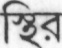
স্থির
